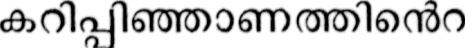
കറിപ്പിഞ്ഞാണത്തിന്റെ
